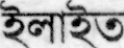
ইলাইত
